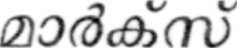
മാര്‍ക്സ്
